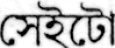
সেইটো
